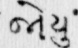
જોયું
